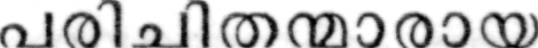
പരിചിതന്മാരായ
